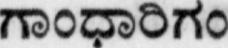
ಗಾಂಧಾರಿಗಂ
